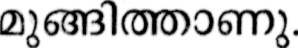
മുങ്ങിത്താണു.
